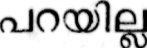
പറയില്ല
